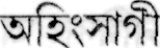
অহিংসাগী
